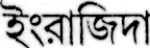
ইংরাজিদা
